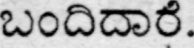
ಬಂದಿದಾರೆ.
